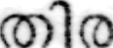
തിര
